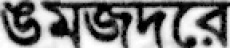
ঙমজদরে
